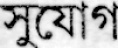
সুযোগ
